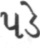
પડે
